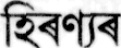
হিৰণ্যৰ
